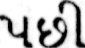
પછી
